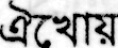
ঐখোয়
